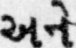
અને
